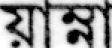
য়াম্না
